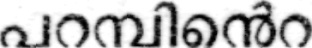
പറമ്പിന്റെ
